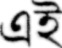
এই
